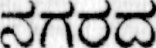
ನಗರದ
